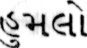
હુમલો
